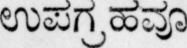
ಉಪಗ್ರಹವೂ
